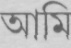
আমি
